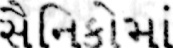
સૈનિકોમાં
